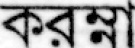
করম্না
